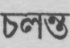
চলন্ত
